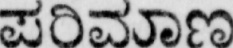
ಪರಿಮಾಣ
